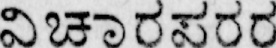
ವಿಚಾರಪರರ
